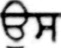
ਉਸ
